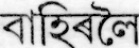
বাহিৰলৈ
